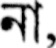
না,
